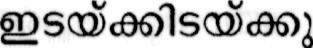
ഇടയ്ക്കിടയ്ക്കു
